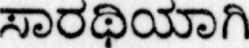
ಸಾರಥಿಯಾಗಿ
